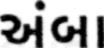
અંબા
